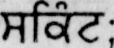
ਸਕਿੰਟ;
